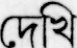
দেখি
